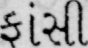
ફાંસી
